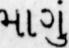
માગું
